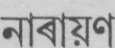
নাৰায়ণ
